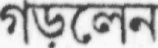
গড়লেন
